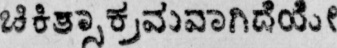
ಚಿಕಿತ್ಸಾಕ್ರಮವಾಗಿದೆಯೇ
